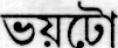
ভয়টো
